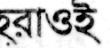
হরাওই
